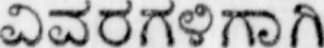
ವಿವರಗಳಿಗಾಗಿ
